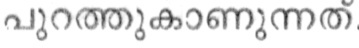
പുറത്തുകാണുന്നത്.
